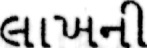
લાખની
